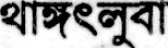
থাঙ্গৎলুবা
